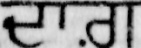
ਦਾਗ਼
